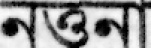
নত্তনা
